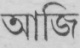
আজি
